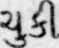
ચુકી
